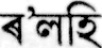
ৰ'লহি
